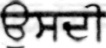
ਉਸਦੀ
